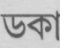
ডকা
